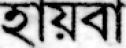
হায়বা
